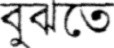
বুঝতে
